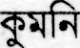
কুমনি
